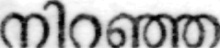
നിറഞ്ഞ
